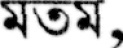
মতম,
